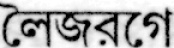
লৈজরগে
